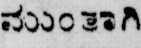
ಮುಂತಾಗಿ
